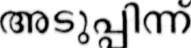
അടുപ്പിന്ന്
